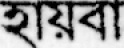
হায়বা
